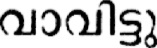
വാവിട്ടു
